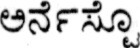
ಅರ್ನೆಸ್ಟೊ
